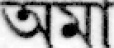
অমা
